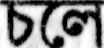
চলে
